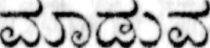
ಮಾಡುವ
